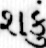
શકું
